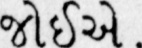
જોઈએ.
